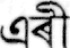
এৰী
